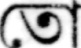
তো
